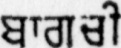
ਬਾਗਚੀ
